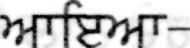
ਆਇਆ-
